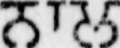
ਨਾਲ
